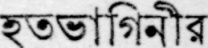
হতভাগিনীর
